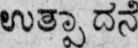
ಉತ್ಪಾದನೆ
